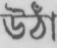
উঠাঁ
